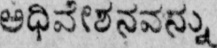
ಅಧಿವೇಶನವನ್ನು
